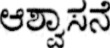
ಆಶ್ವಾಸನೆ
